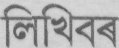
লিখিবৰ
